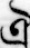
ঐ
